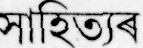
সাহিত্যৰ
